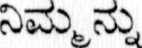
ನಿಮ್ಮನ್ನು
